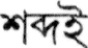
শব্দই
